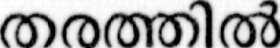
തരത്തില്‍
